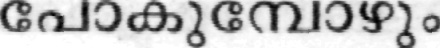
പോകുമ്പോഴും
